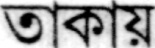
তাকায়
